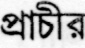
প্রাচীর
